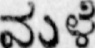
ಮಳೆ
